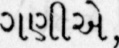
ગણીએ,
